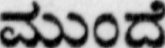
ಮುಂದೆ
